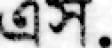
এস.
